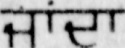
ਜਾਂਦਾ
